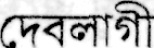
দেবলাগী
